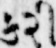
કરી
